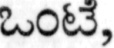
ಒಂಟೆ,
